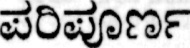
ಪರಿಪೂರ್ಣ
